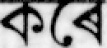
কৰে
